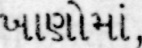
ખાણોમાં,
